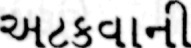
અટકવાની
